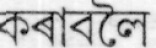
কৰাবলৈ
